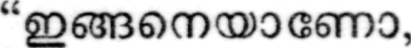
“ഇങ്ങനെയാണോ,
